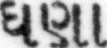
ઘણા
